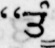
''ਤੂੰ
